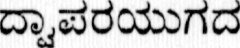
ದ್ವಾಪರಯುಗದ
